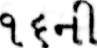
૧૬ની
